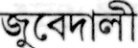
জুবেদালী
